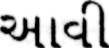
આવી
